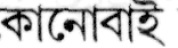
কোনোবাই
